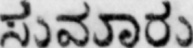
ಸುಮಾರು
